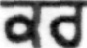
ਕਰ
